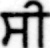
ਸੀ
